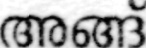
അങ്ങ്
